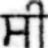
ਸੀ
